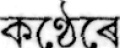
কণ্ঠেৰে
